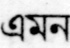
এমন
